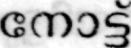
നോട്ട്
